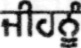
ਜੀਹਨੂੰ
